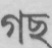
গছ
